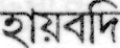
হায়বদি
